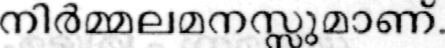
നിര്‍മ്മലമനസ്സുമാണ്.
